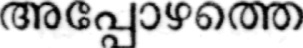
അപ്പോഴത്തെ
